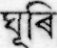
ঘূৰি
